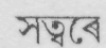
সত্বৰে
